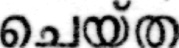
ചെയ്ത
